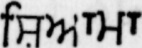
ਸ਼ਿਆਮਾ
